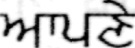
ਆਪਣੇ
